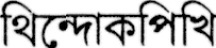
থিন্দোকপিখি
